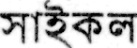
সাইকল
